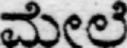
ಮೇಲೆ
